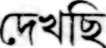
দেখছি
